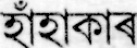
হাঁহাকাৰ
